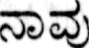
ನಾವು
